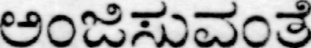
ಅಂಜಿಸುವಂತೆ
